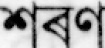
শৰণ
